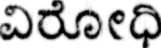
ವಿರೋಧಿ
